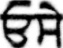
ਓਸੇ
